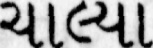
ચાલ્યા
